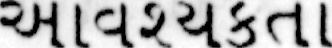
આવશ્યકતા
